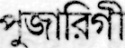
পুজারিগী
